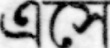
এসে
